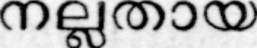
നല്ലതായ
